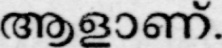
ആളാണ്.
